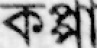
কপ্পা
